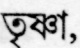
তৃষ্ণা,
